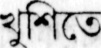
খুশিতে
